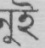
নুই
